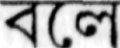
বলে
